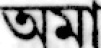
অমা
